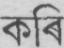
কৰি
